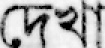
দেখা
